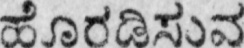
ಹೊರಡಿಸುವ
